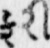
ફરી
